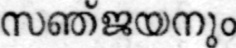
സഞ്ജയനും
